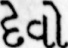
દેવો
